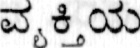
ವ್ಯಕ್ತಿಯ
